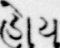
હોય
